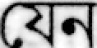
যেন
